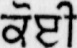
ਕੋਈ
